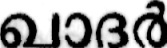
ഖാദര്‍
